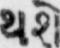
થશે
